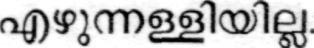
എഴുന്നള്ളിയില്ല.
